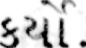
કર્યો.
